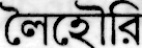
লৈহৌরি
